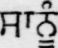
ਸਾਨੂੰ
